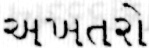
અખતરો
